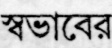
স্বভাবের
